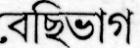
বেছিভাগ
